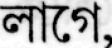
লাগে,
